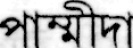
পাম্মীদা
